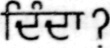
ਦਿੰਦਾ?
